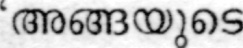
‘അങ്ങയുടെ
